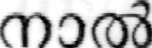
നാല്‍
